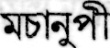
মচানুপী
